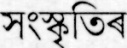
সংস্কৃতিৰ
